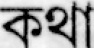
কথা
